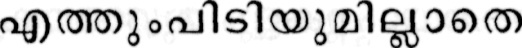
എത്തുംപിടിയുമില്ലാതെ
